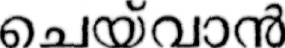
ചെയ്വാന്‍
